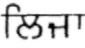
ਲਿਜਾ
